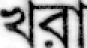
খরা
